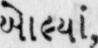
બોલ્યાં,
